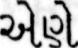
એણે
